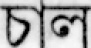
চাল
